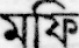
মফি
